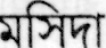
মসিদা
